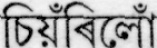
চিয়ঁৰিলোঁ
